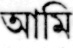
আমি
